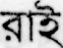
রাই
